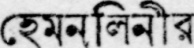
হেমনলিনীর
